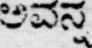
ಅವನ್ನ
